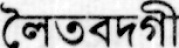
লৈতবদগী
